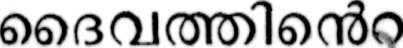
ദൈവത്തിന്റെ
